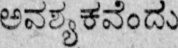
ಅವಶ್ಯಕವೆಂದು
